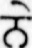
ਨੇ
